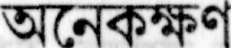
অনেকক্ষণ
